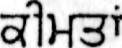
ਕੀਮਤਾਂ
